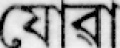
যোৱা
